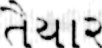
તૈયાર
